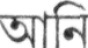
আনি
